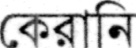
কেরানি
